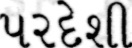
પરદેશી
